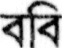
ববি
